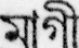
মাগী
